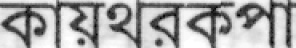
কায়থরকপা
